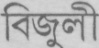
বিজুলী
